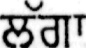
ਲੱਗਾ
